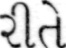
રીતે
